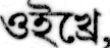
ওইখ্রে,
